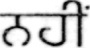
ਨਹੀਂ
